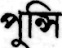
পুন্সি
